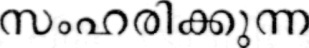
സംഹരിക്കുന്ന
